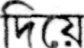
দিয়ে
